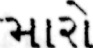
મારો
